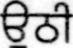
ਉਠੀ
